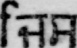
ਜਿਸ
